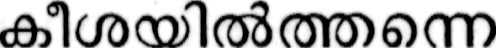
കീശയില്‍ത്തന്നെ
